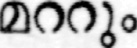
മററും
